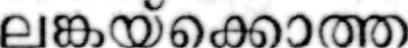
ലങ്കയ്ക്കൊത്ത
